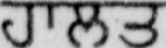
ਹਾਲਤ
